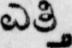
ಎತ್ತಿ
